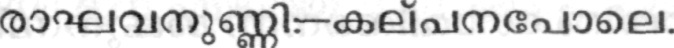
രാഘവനുണ്ണി:-കല്പനപോലെ.
